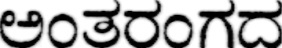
ಅಂತರಂಗದ
